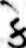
કે
